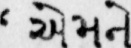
'એમને
